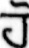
ਹੋ
